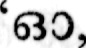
‘ഓ,
